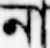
না
